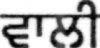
ਵਾਲੀ
